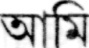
আমি
